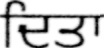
ਦਿਤਾ
